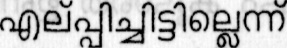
എല്പ്പിച്ചിട്ടില്ലെന്ന്
